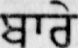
ਬਾਰੇ
